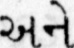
અને
